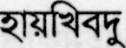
হায়খিবদু
